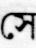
সে
